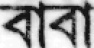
বাবা
